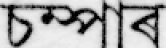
চম্পাৰ
